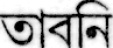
তাবনি
